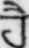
ਹੈ
